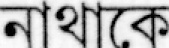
নাথাকে
